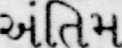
અંતિમ
